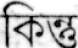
কিন্তু
